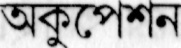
অকুপেশন
